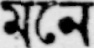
মনে
